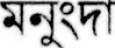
মনুংদা
